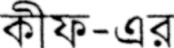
কীফ-এর
